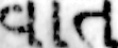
વાત
